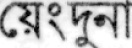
য়েংদুনা
